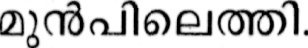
മുന്‍പിലെത്തി.
